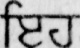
ਇਹ
